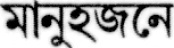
মানুহজনে
